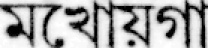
মখোয়গা
